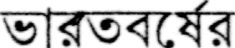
ভারতবর্ষের
